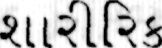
શારીરિક
